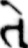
તે
